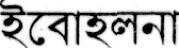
ইবোহলনা
